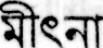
মীৎনা
